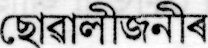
ছোৱালীজনীৰ
